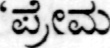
'ಪ್ರೇಮ
